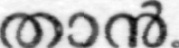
താന്‍.
